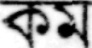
কম
